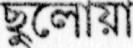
ছুলোয়া
